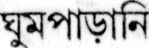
ঘুমপাড়ানি
